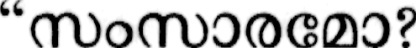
“സംസാരമോ?
